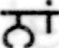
ਨਾਂ
